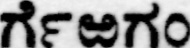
ರ್ಗೆಱಗಂ
